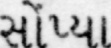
સોંપ્યા
